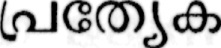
പ്രത്യേക
